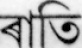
ৰাতি
